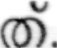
ത്.
